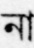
না
